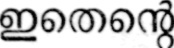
ഇതെന്റെ
